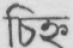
চিহ্ন
